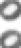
ঃ
